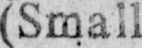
(Small
